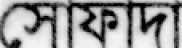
সোফাদা
